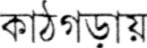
কাঠগড়ায়
